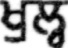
ਖੁਲ੍ਹ
